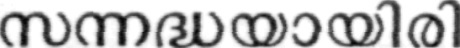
സന്നദ്ധയായിരി
